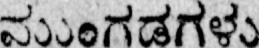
ಮುಂಗಡಗಳು
